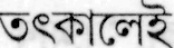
তৎকালেই
